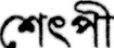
শেৎপী
